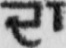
ਦਾ
